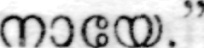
നായേ.”
